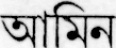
আমিন
